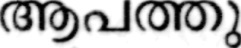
ആപത്തു
